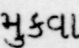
મુકવા
